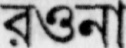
রওনা
